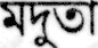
মদুতা
